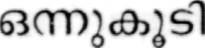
ഒന്നുകൂടി
